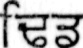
ਢਿਡ
